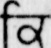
ਕਿ
